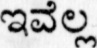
ಇವೆಲ್ಲ
